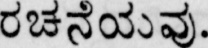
ರಚನೆಯವು.
